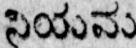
ನಿಯಮ
